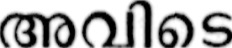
അവിടെ
